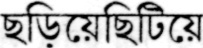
ছড়িয়েছিটিয়ে
